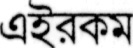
এইরকম
